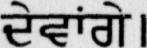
ਦੇਵਾਂਗੇ।
